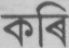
কৰি
